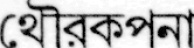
থৌরকপনা
